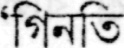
‘গিনতি
